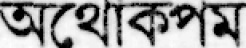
অথোকপম
